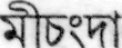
মীচংদা
